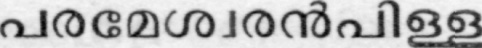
പരമേശ്വരന്‍പിള്ള
